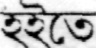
হইতে
